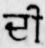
ਦੀ
